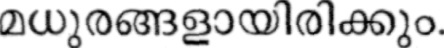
മധുരങ്ങളായിരിക്കും.
